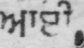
ਆਈ
